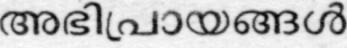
അഭിപ്രായങ്ങള്‍
